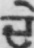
ਦੇ
